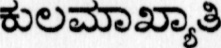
ಕುಲಮಾಖ್ಯಾತಿ
